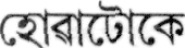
হোৱাটোকে
